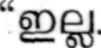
"ഇല്ല.
